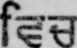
ਵਿਚ
